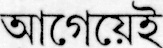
আগেয়েই
